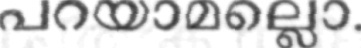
പറയാമല്ലൊ.
